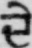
ਦੇ
